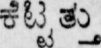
ಕೆಟ್ಟಿತು
